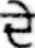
ਦੇ
